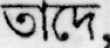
তাদে,
